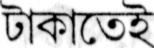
টাকাতেই
